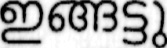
ഇങ്ങട്ടു
